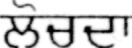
ਲੋਚਦਾ
